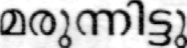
മരുന്നിട്ടു
